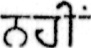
ਨਹੀਂ
